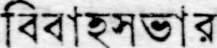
বিবাহসভার
